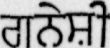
ਗਨੇਸ਼ੀ
